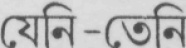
যেনি-তেনি
